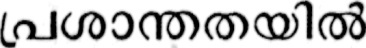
പ്രശാന്തതയില്‍
